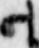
ન
